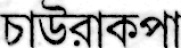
চাউরাকপা
